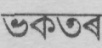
ভকতৰ
